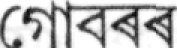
গোবৰৰ
